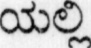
ಯಲ್ಲಿ
